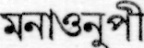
মনাওনুপী
